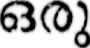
ഒരു
